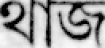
থাজ
